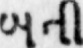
બની
